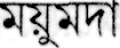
ময়ুমদা
